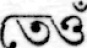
তেওঁ
